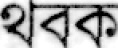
থবক
